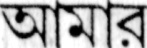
আমার
